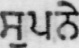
ਸੁਪਨੇ
